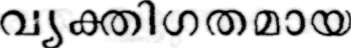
വ്യക്തിഗതമായ
